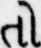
તો
